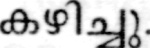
കഴിച്ചു.
